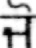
ਜੋ
